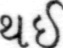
થઈ
